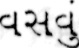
વસવું
